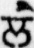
ਲੈ
